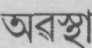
অৱস্থা
